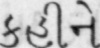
કહીને
